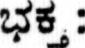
ಭಕ್ತ:
